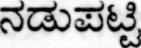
ನಡುಪಟ್ಟಿ
